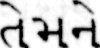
તેમને
